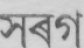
সৰগ
